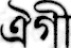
ঐগী
